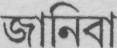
জানিবা
